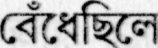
বেঁধেছিলে
